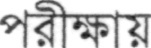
পরীক্ষায়
